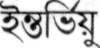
ইন্তর্ভিয়ু
